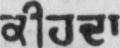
ਕੀਹਦਾ
